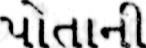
પોતાની
